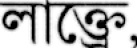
লাক্ত্রে,
